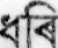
ধৰি
